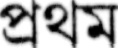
প্রথম
